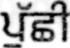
ਪੁੱਛੀ
